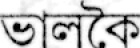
ভালকৈ
